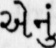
એનું
